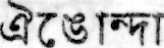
ঐঙোন্দা
